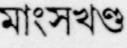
মাংসখণ্ড
